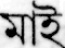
মাই
